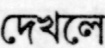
দেখলে
